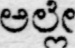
ಅಲ್ಲೇ
